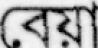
বেয়া
